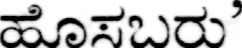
ಹೊಸಬರು'
